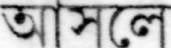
আসলে
